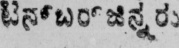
ಟನ್‌ಬರ್‌ಜಿನ್ನರು
